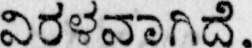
ವಿರಳವಾಗಿದೆ.
